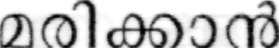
മരിക്കാന്‍
